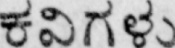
ಕವಿಗಳು
